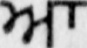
ਆ
